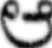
ಆ
